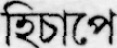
হিচাপে
